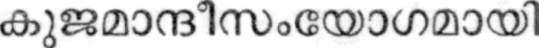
കുജമാന്ദീസംയോഗമായി
